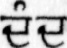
ਦੰਦ
